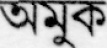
অমুক
